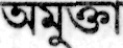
অমুক্তা
